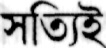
সত্যিই
